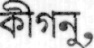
কীগনু,
